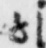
કાં
